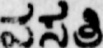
ವಸತಿ
